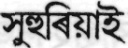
সুহুৰিয়াই
